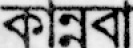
কান্নবা
